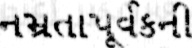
નમ્રતાપૂર્વકની
